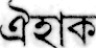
ঐহাক
